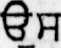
ਉਸ
